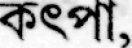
কৎপা,
